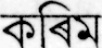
কৰিম
